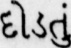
દોડતું
